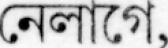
নেলাগে,
